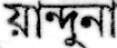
য়ান্দুনা
